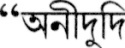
“অনীদুদি
